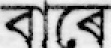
বাৰে
